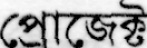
প্রোজেক্ট
